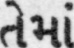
તેમાં
